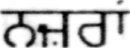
ਨਜ਼ਰਾਂ
